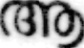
ആ
